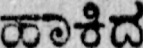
ಹಾಕಿದ
